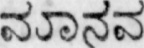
ಮಾನವ
